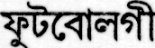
ফুটবোলগী
